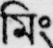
মিং
